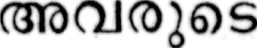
അവരുടെ
